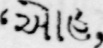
'ઓહ,
